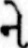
ને
